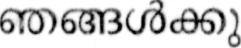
ഞങ്ങള്‍ക്കു
